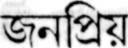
জনপ্রিয়
